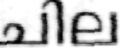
ചില
